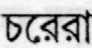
চরেরা
